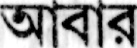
আবার
